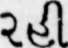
રહી
